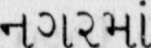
નગરમાં
